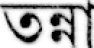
তন্না
